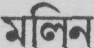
মলিন
